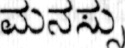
ಮನಸ್ಸು
